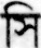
সি
